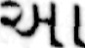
આ
